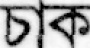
চাক
